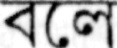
বলে
